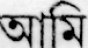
আমি
